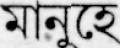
মানুহে
